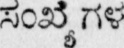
ಸಂಖ್ಯೆಗಳ
